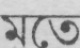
মতে
